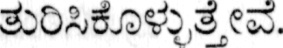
ತುರಿಸಿಕೊಳ್ಳುತ್ತೇವೆ.
